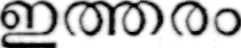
ഇത്തരം
